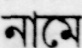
নামে
